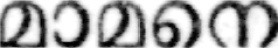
മാമനെ
